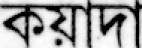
কয়াদা
